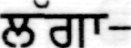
ਲੱਗਾ-
